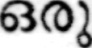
ഒരു
